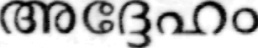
അദ്ദേഹം
